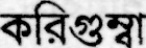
করিগুম্বা
